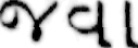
જવા
